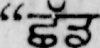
''ਛੱਡ
